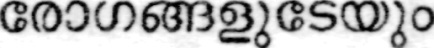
രോഗങ്ങളുടേയും
